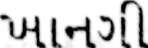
ખાનગી
